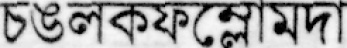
চঙলকফম্লোমদা
